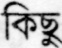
কিছু
